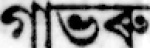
গাভৰু
